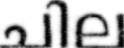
ചില
